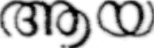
ആയ
